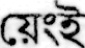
য়েংই
